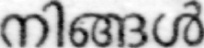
നിങ്ങള്‍
